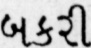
બકરી
